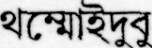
থম্মোইদুবু
